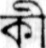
কী
